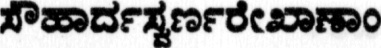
ಸೌಹಾರ್ದಸ್ವರ್ಣರೇಖಾಣಾಂ
